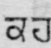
ਕਹ
